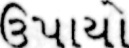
ઉપાયો
